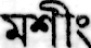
মশীং
